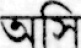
অসি
